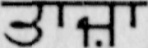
ਤਾਜ਼ਾ
